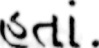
હતાં.
